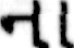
ના
